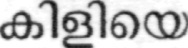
കിളിയെ
